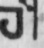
ਹੀ
